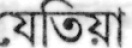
যেতিয়া
